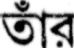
তাঁর
